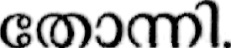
തോന്നി.
